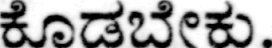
ಕೊಡಬೇಕು.
